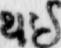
થઈ
